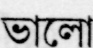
ভালো
